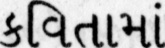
કવિતામાં
